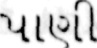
પાણી
